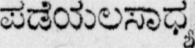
ಪಡೆಯಲಸಾಧ್ಯ
